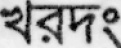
খরদং
